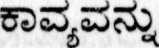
ಕಾವ್ಯವನ್ನು
